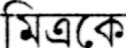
মিত্রকে
